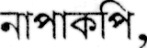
নাপাকপি,
